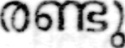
രണ്ടു
